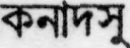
কনাদসু
